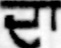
ਦਾ
